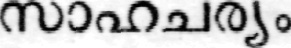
സാഹചര്യം
